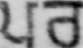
ਪਰ
